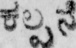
ಕಲ್ಪನೆ
